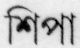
শিপা
